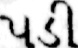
પડી
